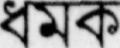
ধমক
